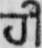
ਹੀ
